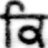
ਕਿ
